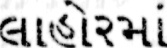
લાહોરમાં
